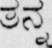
ತನ್ನ
